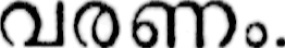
വരണം.
